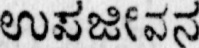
ಉಪಜೀವನ
